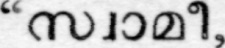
"സ്വാമീ,
